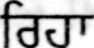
ਰਿਹਾ
